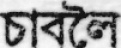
চাবলৈ
